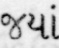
જ્યાં
